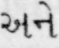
અને
